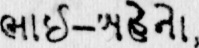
ભાઈ-બહેનો,
